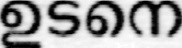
ഉടനെ
